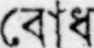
বোধ
